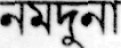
নমদুনা
